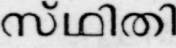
സ്ഥിതി
